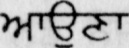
ਆਉਣਾ
